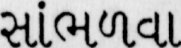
સાંભળવા
